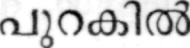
പുറകില്‍
